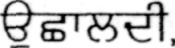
ਉਛਾਲਦੀ,
